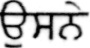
ਉਸਨੇ
